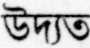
উদ্যত
